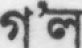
গ'ল
